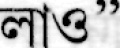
লাও”
